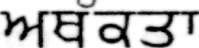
ਅਥੱਕਤਾ
